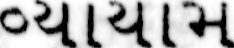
વ્યાયામ
